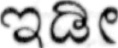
ಇಡೀ
